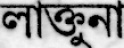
লাক্তুনা
